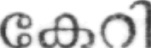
കേറി
